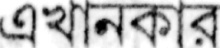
এখানকার
